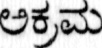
ಅಕ್ರಮ
